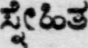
ಸ್ನೇಹಿತ
